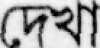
দেখা
